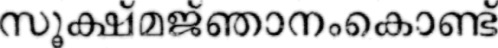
സൂക്ഷ്മജ്ഞാനംകൊണ്ട്
